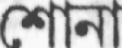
শোনা
